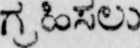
ಗ್ರಹಿಸಲು
